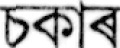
চকাৰ
